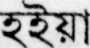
হইয়া
